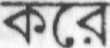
করে
